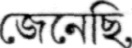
জেনেছি,
